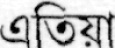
এতিয়া
